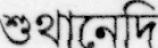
শুথানেদি
